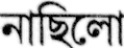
নাছিলো
